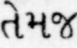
તેમજ
